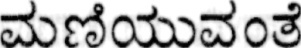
ಮಣಿಯುವಂತೆ
